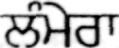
ਲੰਮੇਰਾ
